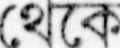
থেকে
